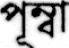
পূম্বা
